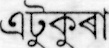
এটুকুৰা
